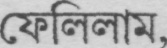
ফেলিলাম,
